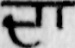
ਦਾ
